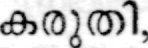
കരുതി,
